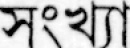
সংখ্যা
